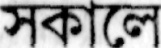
সকালে
